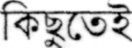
কিছুতেই
